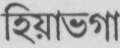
হিয়াভগা
